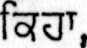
ਕਿਹਾ,
